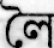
লৈ
